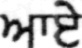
ਆਏ
